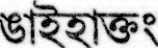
ঙাইহাক্তং
